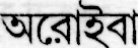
অরোইবা
